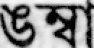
ঙম্বা
